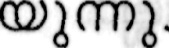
യുന്നു.
